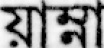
য়াম্না
